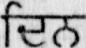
ਦਿਨ
